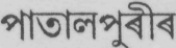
পাতালপুৰীৰ
